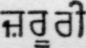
ਜ਼ਰੂਰੀ
